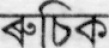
ৰুচিক
